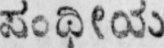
ಪಂಥೀಯ
